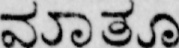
ಮಾತೂ
